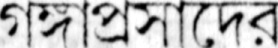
গঙ্গাপ্রসাদের
